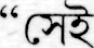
"সেই
